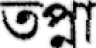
তপ্না
